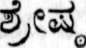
ಶ್ರೇಷ್ಠ
